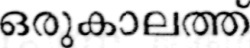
ഒരുകാലത്ത്
